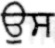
ਉਸ
